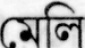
মেলি
